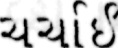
ચર્ચાઈ
